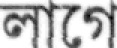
লাগে
